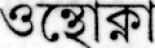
ওন্থোক্না
